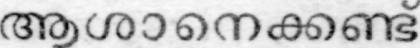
ആശാനെക്കണ്ട്
